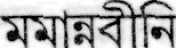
মমান্নবীনি
